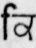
ਕਿ
